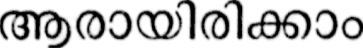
ആരായിരിക്കാം
